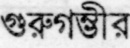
গুরুগম্ভীর
